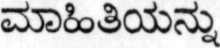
ಮಾಹಿತಿಯನ್ನು
